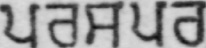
ਪਰਸਪਰ
